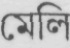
মেলি
